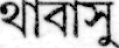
থাবাসু
